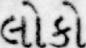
લોકો
